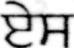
ਏਸ
